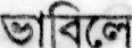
ভাবিলে
